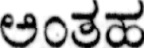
ಅಂತಹ
